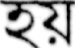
হয়
